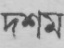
দশম
